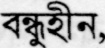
বন্ধুহীন,
